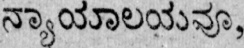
ನ್ಯಾಯಾಲಯವೂ,
